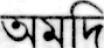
অমদি
